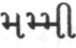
મમ્મી
